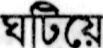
ঘটিয়ে
